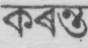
কৰন্ত
